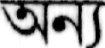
অন্য
